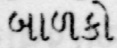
બાળકો
